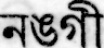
নঙগী
